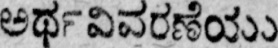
ಅರ್ಥವಿವರಣೆಯು
